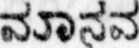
ಮಾನವ
